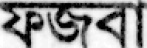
ফজবা
